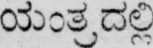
ಯಂತ್ರದಲ್ಲಿ
